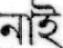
নাই
